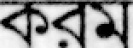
করম
